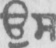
ਉਸ
